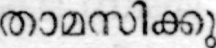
താമസിക്കു
